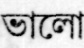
ভালো
